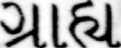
ગ્રાહ્ય
